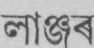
লাঞ্জৰ
